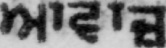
ਆਵਾਜ਼
